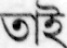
তাই
